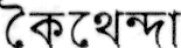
কৈথেন্দা
